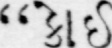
"કોઈ
